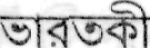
ভারতকী
